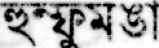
হুম্ফুমঙা
